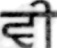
ਵੀ
